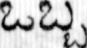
ಒಬ್ಬ
